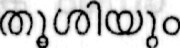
തൂശിയും
